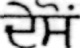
ਦੇਸੋਂ
